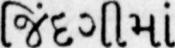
જિંદગીમાં
